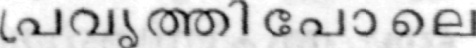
പ്രവൃത്തിപോലെ
